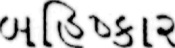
બહિષ્કાર
